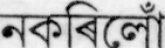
নকৰিলোঁ
